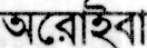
অরোইবা
